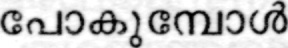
പോകുമ്പോള്‍
